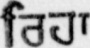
ਰਿਹਾ
